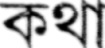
কথা
